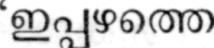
'ഇപ്പഴത്തെ
